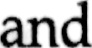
and
